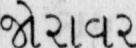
જોરાવર
